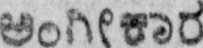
ಅಂಗೀಕಾರ
